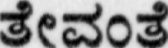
ತೇವಂತೆ
